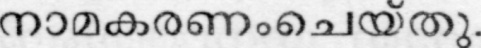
നാമകരണംചെയ്തു.
